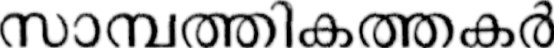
സാമ്പത്തികത്തകര്‍
